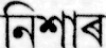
নিশাৰ
